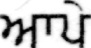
ਆਪੇ
